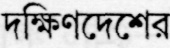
দক্ষিণদেশের
